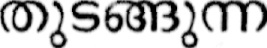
തുടങ്ങുന്ന
